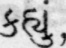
કહ્યું,
